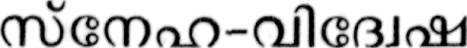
സ്നേഹ-വിദ്വേഷ
